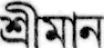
শ্রীমান
